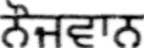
ਨੌਜਵਾਨ
